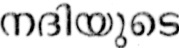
നദിയുടെ
